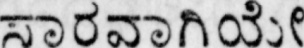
ಸಾರವಾಗಿಯೇ
